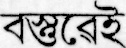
বস্তুৱেই
